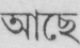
আছে
